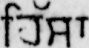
ਹਿੱਸਾ
